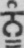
ਨੂੰ
